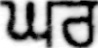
ਘਰ
